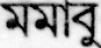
মমাবু
